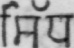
ਸਿੱਧ
